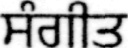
ਸੰਗੀਤ
